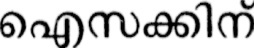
ഐസക്കിന്
